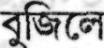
বুজিলে
